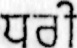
ਧਰੀ
